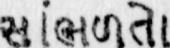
સાંભળતો
